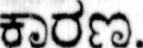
ಕಾರಣ.
